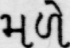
મળે
